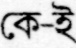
কে-ই
